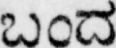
ಬಂದ
